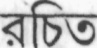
রচিত
